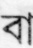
বা
